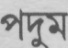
পদুম
